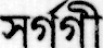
সর্গগী
